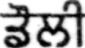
ਡੌਲੀ
